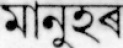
মানুহৰ
